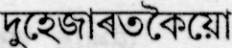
দুহেজাৰতকৈয়ো
